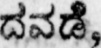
ದವಡೆ,
